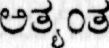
ಅತ್ಯಂತ
